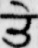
ਤੇ
